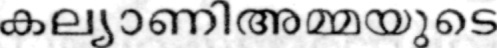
കല്യാണിഅമ്മയുടെ
